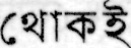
থোকই
